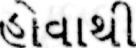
હોવાથી
